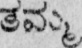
ತಮ್ಮ
